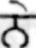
ਨੇ
